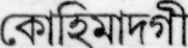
কোহিমাদগী
